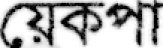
য়েকপা
